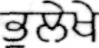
ਭੁਲੇਖੇ
